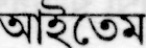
আইতেম
